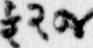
ફરજ
